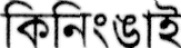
কিনিংঙাই
